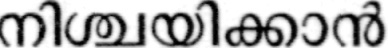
നിശ്ചയിക്കാന്‍
